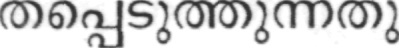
തപ്പെടുത്തുന്നതു
